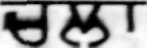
ਚਲਾ
